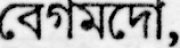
বেগমদো,
